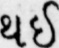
થઈ
